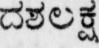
ದಶಲಕ್ಷ
